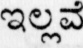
ಇಲ್ಲವೆ
